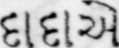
દાદાએ
